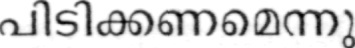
പിടിക്കണമെന്നു
